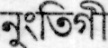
নুংতিগী
